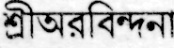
শ্রীঅরিবন্দনা
